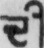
ਦੀ
